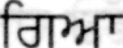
ਗਿਆ
